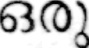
ഒരു
